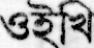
ওইখি
